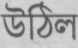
উঠিল
